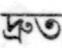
দ্রুত
